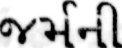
જર્મની
